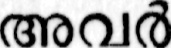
അവര്‍
